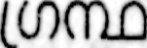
ഗ്രന്ഥ
